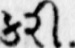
કરી.'
